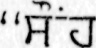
''ਸੌਂਹ
